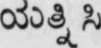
ಯತ್ನಿಸಿ
